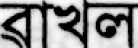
ৱাখল
